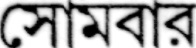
সোমবার
